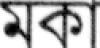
মকা
